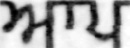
ਆਪ
